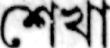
শেখা
